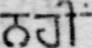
ਨਹੀਂ
